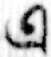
এ
